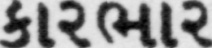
કારભાર
